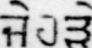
ਜੇਹੜੇ
